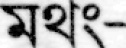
মথং-
